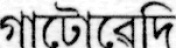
গাটোৱেদি
